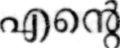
എന്റെ
